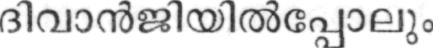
ദിവാന്‍ജിയില്‍പ്പോലും
